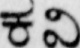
ಕವಿ
